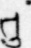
તું
